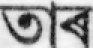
তাৰ
